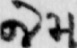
જેમ
